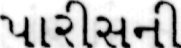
પારીસની
